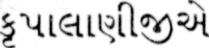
કૃપાલાણીજીએ
